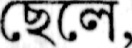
ছেলে,
